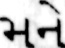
મને
